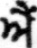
ਐਂ
